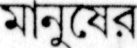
মানুষের
